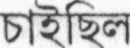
চাইছিল
